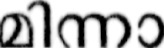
മിന്നാ
